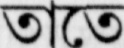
তাতে
